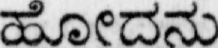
ಹೋದನು
